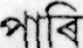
পাৰি
